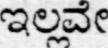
ಇಲ್ಲವೇ
